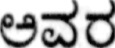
ಅವರ
